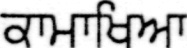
ਕਾਮਾਖਿਆ
